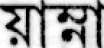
য়াম্না
